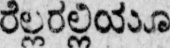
ರೆಲ್ಲರಲ್ಲಿಯೂ
